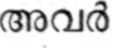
അവര്‍
